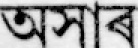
অসাৰ
